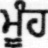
ਮੂੰਹ
